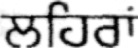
ਲਹਿਰਾਂ
